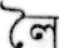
লৈ
